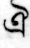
ঐ
